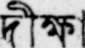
দীক্ষা
